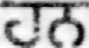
ਹਨ
